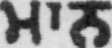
ਮਾਨ
